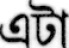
এটা
